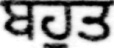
ਬਹੁਤ
